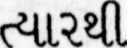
ત્યારથી
